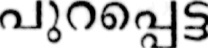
പുറപ്പെട്ട
